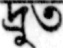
দ্রুত
